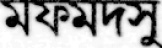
মফমদসু
